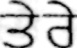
ਤੇਰੇ
